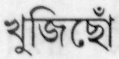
খুজিছোঁ
